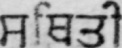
ਸਥਿਤੀ
